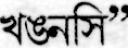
খঙনসি”
